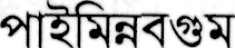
পাইমিন্নবগুম
